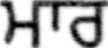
ਮਾਰ
